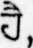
ਹੈ,
